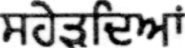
ਸਹੇੜਦਿਆਂ
